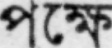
পক্ষে
